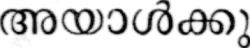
അയാള്‍ക്കു
